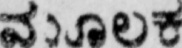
ಮೂಲಕ
